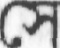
সে
